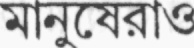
মানুষেরাও
